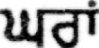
ਘਰਾਂ
